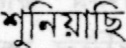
শুনিয়াছি
